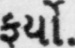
ફર્યો.
